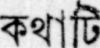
কথাটি
